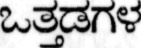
ಒತ್ತಡಗಳ
